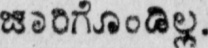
ಜಾರಿಗೊಂಡಿಲ್ಲ.
